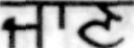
ਜਾਣ
